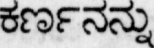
ಕರ್ಣನನ್ನು
